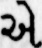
એ
